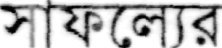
সাফল্যের
